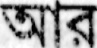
আর
